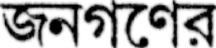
জনগণের
